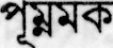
পূম্নমক
